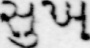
સુખ
